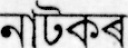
নাটকৰ
